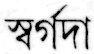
স্বর্গদা
